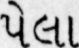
પેલા
